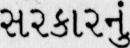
સરકારનું
